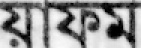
য়াফম
